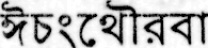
ঈচংথৌরবা
